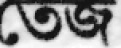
তেজ
